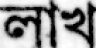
লাখ
